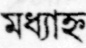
মধ্যাহ্ন
